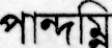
পান্দম্নি
